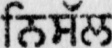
ਨਿਸੱਲ
